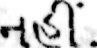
નહીં.
